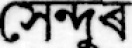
সেন্দুৰ
